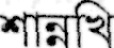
শান্নখি
